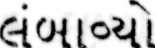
લંબાવ્યો
